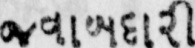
જવાબદારી
